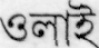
ওলাই
